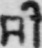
ਸੀ
